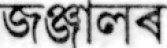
জঞ্জালৰ
